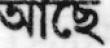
আছে
